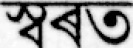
স্বৰত
